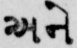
અને
